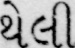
થેલી
